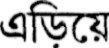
এড়িয়ে
